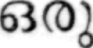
ഒരു
